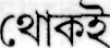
থোকই
